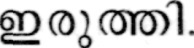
ഇരുത്തി.
